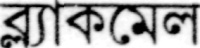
ব্ল্যাকমেল
